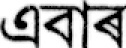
এবাৰ
